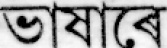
ভাষাৰে
